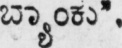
ಬ್ಯಾಂಕು”.
